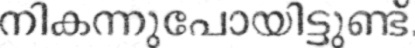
നികന്നുപോയിട്ടുണ്ട്.
